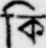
কি
